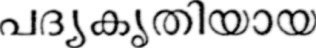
പദ്യകൃതിയായ
